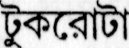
টুকরোটা
